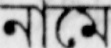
নামে
